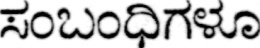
ಸಂಬಂಧಿಗಳೂ
